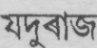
যদুৰাজ
